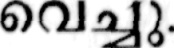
വെച്ചു.
